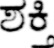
ಶಕ್ತಿ
